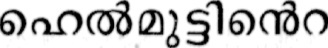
ഹെല്‍മുട്ടിന്റെ
